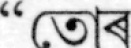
"তোৰ
